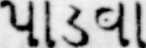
પાડવા
